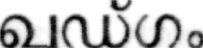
ഖഡ്ഗം
